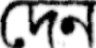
দেন
